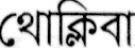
থোক্লিবা
